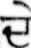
ਦੇ
